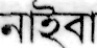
নাইবা
